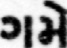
ગમે
